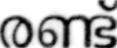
രണ്ട്
